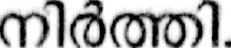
നിര്‍ത്തി.
